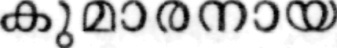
കുമാരനായ
